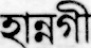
হান্নগী
